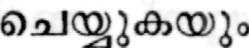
ചെയ്യുകയും
